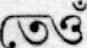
তেওঁ
